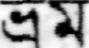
ভ্রম
